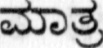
ಮಾತ್ರ
